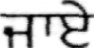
ਜਾਏ
